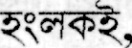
হংলকই,
